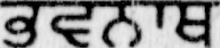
ਭਵਨਾਥ
